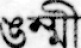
ঙম্মী
